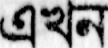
এখন
